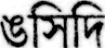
ঙসিদি
